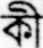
কী
